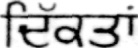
ਦਿੱਕਤਾਂ
